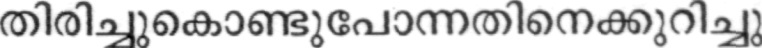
തിരിച്ചുകൊണ്ടുപോന്നതിനെക്കുറിച്ചു
